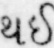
થઈ
